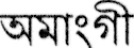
অমাংগী
